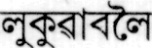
লুকুৱাবলৈ
